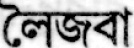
লৈজবা
